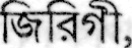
জিরিগী,
